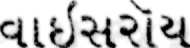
વાઇસરૉય
